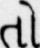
તો
